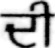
ਦੀ
